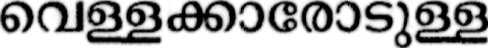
വെള്ളക്കാരോടുള്ള
